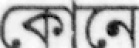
কোনে
